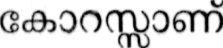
കോറസ്സാണ്
